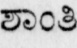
ಶಾಂತಿ
